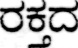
ರಕ್ತದ
